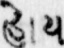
હોય
